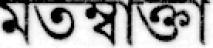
মতম্বাক্তা
